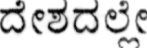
ದೇಶದಲ್ಲೇ
